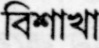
বিশাখা
